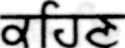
ਕਹਿਣ
